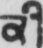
ਕੀ
